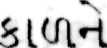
કાળને
